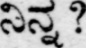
ನಿನ್ನ?
